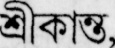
শ্রীকান্ত,
